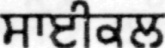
ਸਾਈਕਲ
